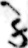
કે
